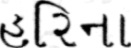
હરિના
